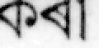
কৰা
